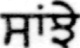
ਸਾਂਝੇ
